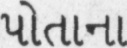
પોતાના
